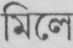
মিলে
